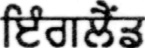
ਇੰਗਲੈਂਡ
